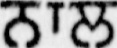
ਨਾਲ
